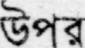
উপর
